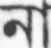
না
